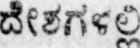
ದೇಶಗಳಲ್ಲಿ
